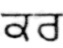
ਕਰ
